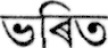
ভৰিত
